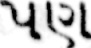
પણ
